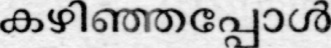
കഴിഞ്ഞപ്പോള്‍
